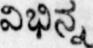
ವಿಭಿನ್ನ
